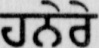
ਹਨੇਰੇ
